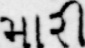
મારી
